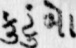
કુટુંબો
